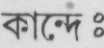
কান্দেঃ
